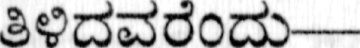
ತಿಳಿದವರೆಂದು-
